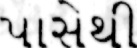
પાસેથી
